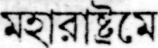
মহারাষ্ট্রমে
